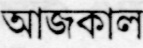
আজকাল
